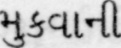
મુકવાની
